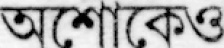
অশোকেও
